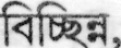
বিচ্ছিন্ন,
